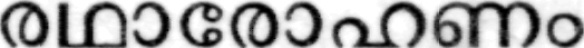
രഥാരോഹണം
